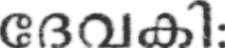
ദേവകി:
